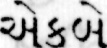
એકબે
